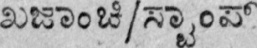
ಖಜಾಂಚಿ/ಸ್ಟಾಂಪ್
